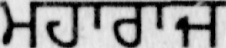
ਮਹਾਰਾਜ
